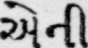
એની
